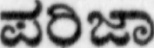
ಪರಿಜಾ
